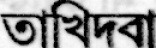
তাখিদবা
